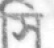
সি
